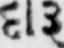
દારૂ
